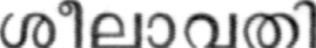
ശീലാവതി
